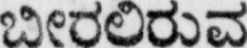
ಬೀರಲಿರುವ
